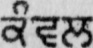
ਕੰਵਲ
